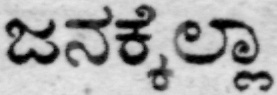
ಜನಕ್ಕೆಲ್ಲಾ
